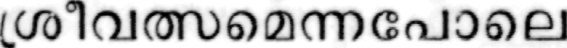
ശ്രീവത്സമെന്നപോലെ
